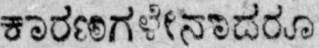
ಕಾರಣಗಳೇನಾದರೂ
